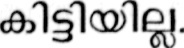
കിട്ടിയില്ല.
